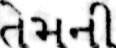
તેમની
